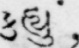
ક્હયું,
